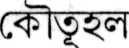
কৌতূহল
